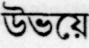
উভয়ে
